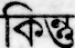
কিন্তু
